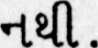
નથી.
